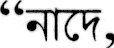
“নাদে,
